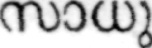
സാധു
